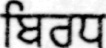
ਬਿਰਧ
